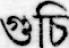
গুচি
